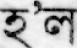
হ'ল
